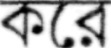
করে
